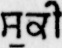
ਸੁਕੀ
